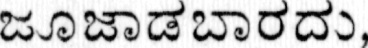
ಜೂಜಾಡಬಾರದು,
